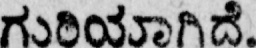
ಗುರಿಯಾಗಿದೆ.
